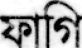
ফাগি
